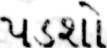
પડશો
